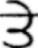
ਤੇ
